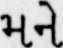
મને
